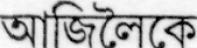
আজিলৈকে
